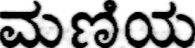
ಮಣಿಯ
